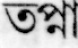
তপ্না
